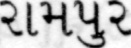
રામપુર
